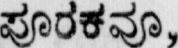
ಪೂರಕವೂ,
